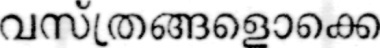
വസ്ത്രങ്ങളൊക്കെ
